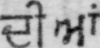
ਦੀਆਂ
